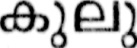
കുലു
